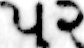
પર
